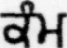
ਕੰਮ
